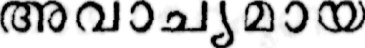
അവാച്യമായ
